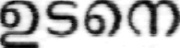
ഉടനെ
